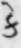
કે
